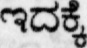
ಇದಕ್ಕೆ
